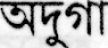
অদুগা
